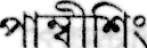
পাম্বীশিং
